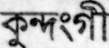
কুন্দংগী
